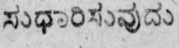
ಸುಧಾರಿಸುವುದು
